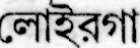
লোইরগা
